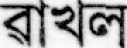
ৱাখল
